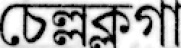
চেল্লক্লগা
